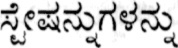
ಸ್ಟೇಷನ್ನುಗಳನ್ನು
